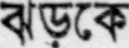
ঝড়কে
